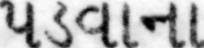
પડવાના
